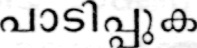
പാടിപ്പുക
